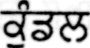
ਕੁੰਡਲ
